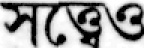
সত্ত্বেও
